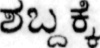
ಶಬ್ದಕ್ಕೆ
